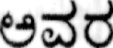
ಅವರ
